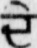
ਦੇ
